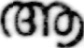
ആ
